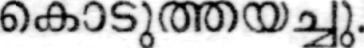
കൊടുത്തയച്ചു.
